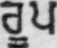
ਰੂਪ
